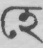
হে
